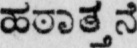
ಹಠಾತ್ತನೆ
